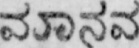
ಮಾನವ
